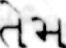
તેમ
